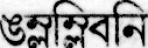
ঙম্লম্লিবনি
